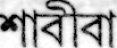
শাবীবা
